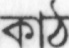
কাঠ
